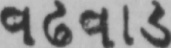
વઢવાડ
